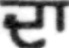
ਦਾ
